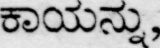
ಕಾಯನ್ನು,
